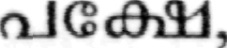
പക്ഷേ,
